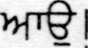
ਆਉ!
